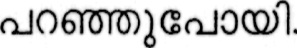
പറഞ്ഞുപോയി.
